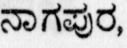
ನಾಗಪುರ,
